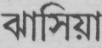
ঝাসিয়া
